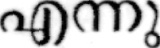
എന്നു
